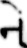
ને
